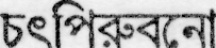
চৎপিরুবনো
